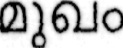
മുഖം
